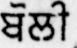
ਬੋਲੀ
